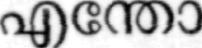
എന്തോ
